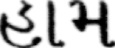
હામ
